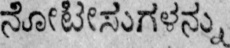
ನೋಟೀಸುಗಳನ್ನು
